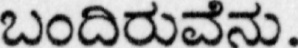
ಬಂದಿರುವೆನು.
